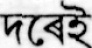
দৰেই
